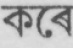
কৰে
